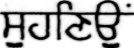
ਸੁਹਣਿਉਂ
